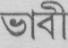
ভাবী
